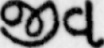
જીવ
